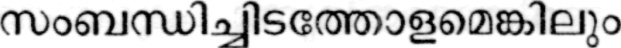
സംബന്ധിച്ചിടത്തോളമെങ്കിലും
